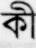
কী
